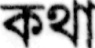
কথা
